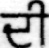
ਦੀ
